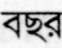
বছর
